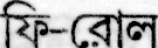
ফি-রোল
